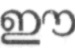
ഈ
